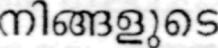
നിങ്ങളുടെ
